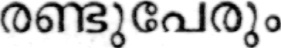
രണ്ടുപേരും
